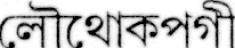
লৌথোকপগী
